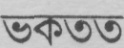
ভকতত
